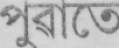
পুৱাতে
